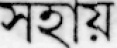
সহায়
